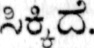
ಸಿಕ್ಕಿದೆ.
